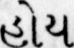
હોય
